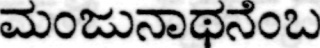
ಮಂಜುನಾಥನೆಂಬ
